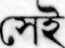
সেই
